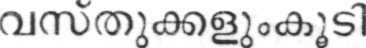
വസ്തുക്കളുംകൂടി
